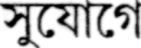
সুযোগে
